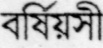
বর্ষিয়সী
